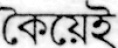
কৈয়েই
